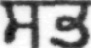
ਸਭ
